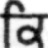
ਕਿ
